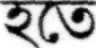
হতে
